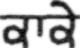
ਕਾਕੇ
